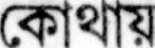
কোথায়
